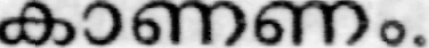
കാണണം.
